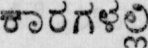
ಕಾರಗಳಲ್ಲಿ
